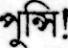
পুন্সি!
